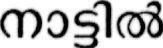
നാട്ടില്‍
